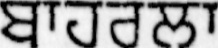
ਬਾਹਰਲਾ
